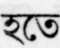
হতে
